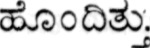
ಹೊಂದಿತ್ತು.
